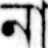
না
